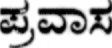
ಪ್ರವಾಸ
